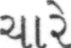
ચારે
